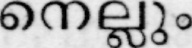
നെല്ലും
